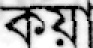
কয়া
